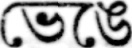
ভেঙে
